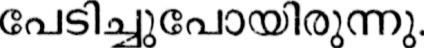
പേടിച്ചുപോയിരുന്നു.
